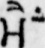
ਮੈਂ
